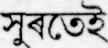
সুৰতেই
